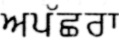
ਅਪੱਛਰਾ
